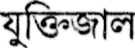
যুক্তিজাল
